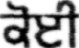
ਕੋਈ
